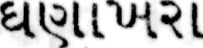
ઘણાખરા
